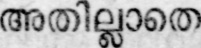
അതില്ലാതെ
